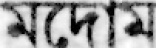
মদোম
